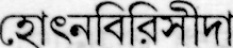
হোৎনবিরিসীদা
